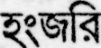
হংজরি
